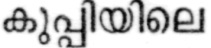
കുപ്പിയിലെ
